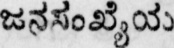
ಜನಸಂಖ್ಯೆಯ
